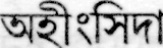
অহীংসিদা
